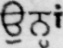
ਉਨ੍ਹਾਂ
